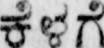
ಕೆಳಗೆ
